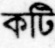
কটি
